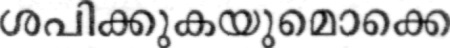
ശപിക്കുകയുമൊക്കെ
